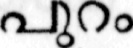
പുറം
